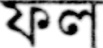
ফল
